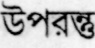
উপরন্তু
